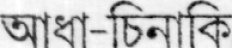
আধা-চিনাকি
